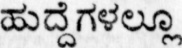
ಹುದ್ದೆಗಳಲ್ಲೂ
